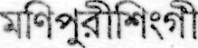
মণিপুরীশিংগী
